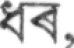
ধৰ,
